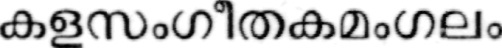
കളസംഗീതകമംഗലം
